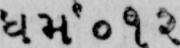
ધર્મ.૧૨
